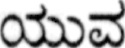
ಯುವ
